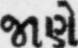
જાણે
